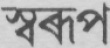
স্বৰূপ
